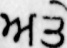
ਅਤੇ
